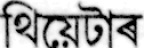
থিয়েটাৰ
